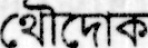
থৌদোক
